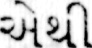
એથી
